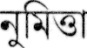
নুমিত্তা
